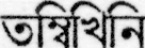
তম্বিখিনি
